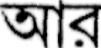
আর
